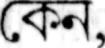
কেন,
